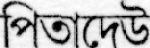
পিতাদেউ
